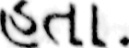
હતા.
